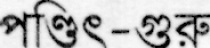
পণ্ডিৎ-গুরু
